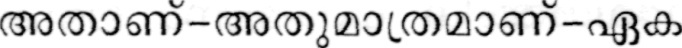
അതാണ്-അതുമാത്രമാണ്-ഏക
